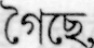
গৈছে,
